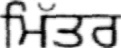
ਮਿੱਤਰ
